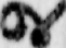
જ
